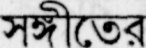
সঙ্গীতের
